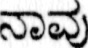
ನಾವು
